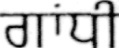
ਗਾਂਧੀ
